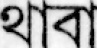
থাবা
